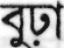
বুঢ়া
